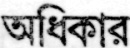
অধিকার
